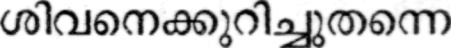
ശിവനെക്കുറിച്ചുതന്നെ
